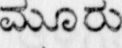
ಮೂರು
